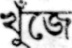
খুঁজে
